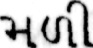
મળી
